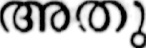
അതു
